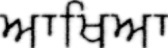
ਆਖਿਆ
